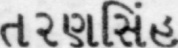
તરણસિંહ
